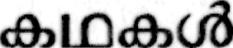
കഥകള്‍
